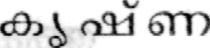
കൃഷ്ണ
